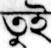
তুই
